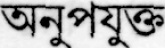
অনুপযুক্ত
